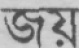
জয়
